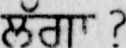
ਲੱਗਾ?
